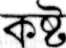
কষ্ট
